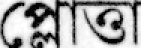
প্লোত্তা
